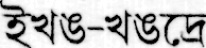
ইখঙ-খঙদ্রে
